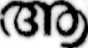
ആ
